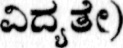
ವಿದ್ಯತೇ)
